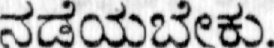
ನಡೆಯಬೇಕು.
